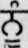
ਨੂੰ
